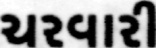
ચરવારી
